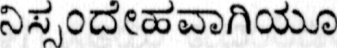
ನಿಸ್ಸಂದೇಹವಾಗಿಯೂ
